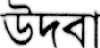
উদবা
